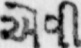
એવી
